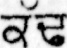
ਕੱਢ
